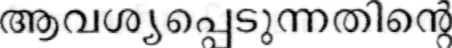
ആവശ്യപ്പെടുന്നതിന്റെ
